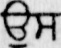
ਉਸ
